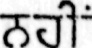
ਨਹੀਂ
